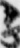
કે
